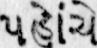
પહોંચે
